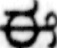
ಈ
